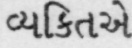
વ્યક્તિએ
